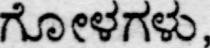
ಗೋಳಗಳು,
